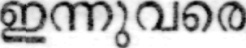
ഇന്നുവരെ
